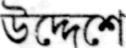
উদ্দেশে
